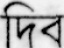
দিব
